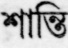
শান্তি
